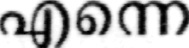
എന്നെ
